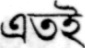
এতই
